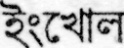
ইংখেল
